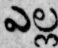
ಎಲ್ಲ
